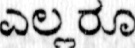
ಎಲ್ಲರೂ
